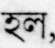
হল,
